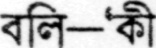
বলি—‘কী
